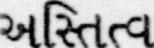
અસ્તિત્વ
